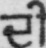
ਦੀ
